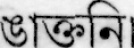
ঙাক্তনি।
